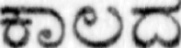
ಕಾಲದ
